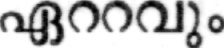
ഏററവും
